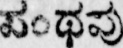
ಪಂಥವು
